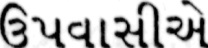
ઉપવાસીએ
